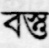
বস্তু
